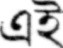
এই
